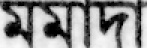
মমাদা
